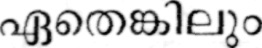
ഏതെങ്കിലും
